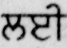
ਲਈ
